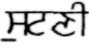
ਸੁਟਣੀ
